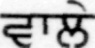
ਵਾਲੇ
